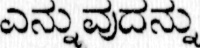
ಎನ್ನುವುದನ್ನು
